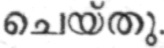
ചെയ്തു.
